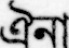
ঐনা
